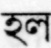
হল
